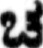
ಚ
